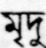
মৃদু
